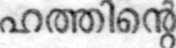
ഹത്തിന്റെ
